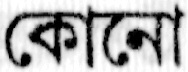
কোনো
